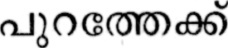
പുറത്തേക്ക്
